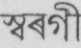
স্বৰগী
